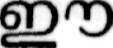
ഈ
